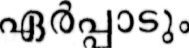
ഏര്‍പ്പാടും
